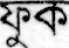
ফুক
